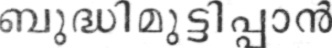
ബുദ്ധിമുട്ടിപ്പാന്‍
